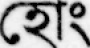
হোং
